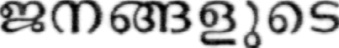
ജനങ്ങളുടെ
